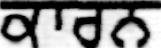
ਕਾਰਨ
